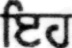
ਇਹ
